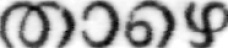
താഴെ
